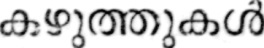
കഴുത്തുകള്‍
